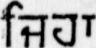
ਜਿਹਾ
